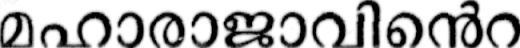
മഹാരാജാവിന്റെ
